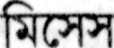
মিসেস
